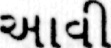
આવી
